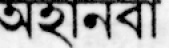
অহানবা
